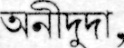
অনীদুদা,
